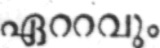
ഏററവും
